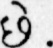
છે.
